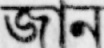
জান
